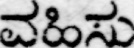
ವಹಿಸು
